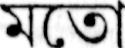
মতো
